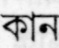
কান
